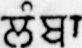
ਲੰਬਾ
